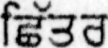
ਛਿੱਤਰ
